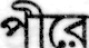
পীরে
